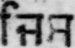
ਜਿਸ
